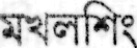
মখলশিং
